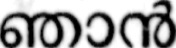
ഞാന്‍
